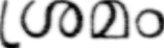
ശ്രമം
